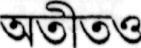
অতীতও
